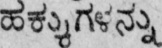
ಹಕ್ಕುಗಳನ್ನು
